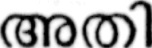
അതി
